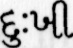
દુઃખી
